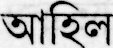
আহিল
